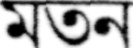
মতন
